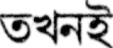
তখনই
